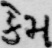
કેમ
